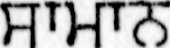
ਸਾਮਾਨ
